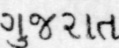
ગુજરાત
